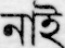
নাই
